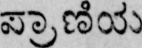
ಪ್ರಾಣಿಯ
